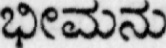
ಭೀಮನು
